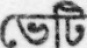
ভেটি
